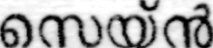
സെയ്ന്‍
